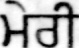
ਮੇਰੀ
